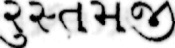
રુસ્તમજી
